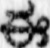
ಈ
